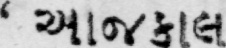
'આજકાલ
